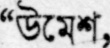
‘‘উমেশ,
